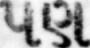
પણ
